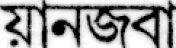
য়ানজবা
